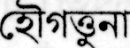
হৌগত্তুনা
